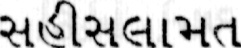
સહીસલામત
